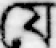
যে
